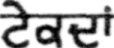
ਟੇਕਦਾਂ
